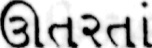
ઊતરતાં
